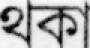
থকা
